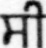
ਸੀ
